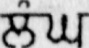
ਲੰਘ
